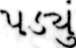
પડ્યું
